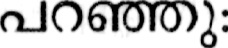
പറഞ്ഞു:
